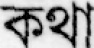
কথা
